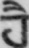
ਹੈ
